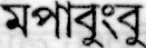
মপাবুংবু
